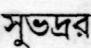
সুভদ্রর
